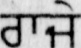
ਰਾਜੇ
